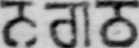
ਨਗਠ
